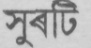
সুৰটি
